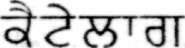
ਕੈਟੇਲਾਗ
